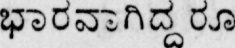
ಭಾರವಾಗಿದ್ದರೂ
